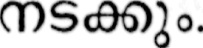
നടക്കും.
